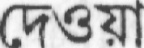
দেওয়া
